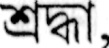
শ্রদ্ধা,
